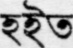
হইত
